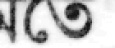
মতে
